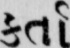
કર્તા
